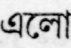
এলো
